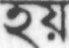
হয়
